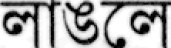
লাঙলে
